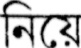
নিয়ে
